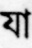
যা
